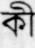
কী
